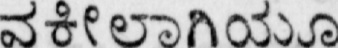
ವಕೀಲಾಗಿಯೂ
